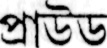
প্রাউড
